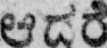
ಆದರೆ
